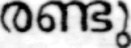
രണ്ടു
